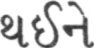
થઈને
